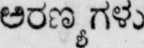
ಅರಣ್ಯಗಳು
